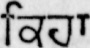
ਕਿਹਾ
